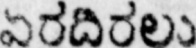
ಏರದಿರಲು
